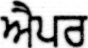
ਐਪਰ
